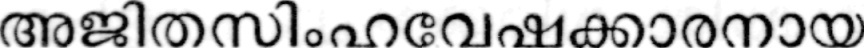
അജിതസിംഹവേഷക്കാരനായ
